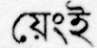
য়েংই
